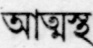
আত্মস্থ
